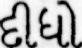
દીધો
